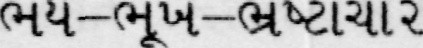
ભય-ભૂખ-ભ્રષ્ટાચાર
